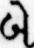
બે
